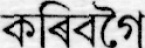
কৰিবগৈ
